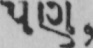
પણ,
